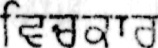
ਵਿਚਕਾਰ
